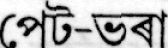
পেট-ভৰা
